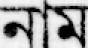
নাম
